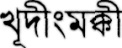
খূদীংমক্কী
